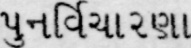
પુનર્વિચારણા
